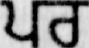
ਪਰ
